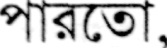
পারতো,
